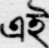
এই
